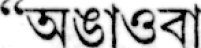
“অঙাওবা
